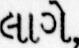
લાગે,
